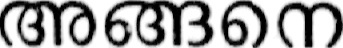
അങ്ങനെ
